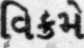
વિક્રમે
